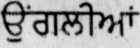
ਉਂਗਲੀਆਂ
